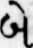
બે
